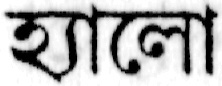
হ্যালো
